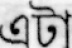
এটা
